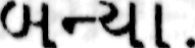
બન્યા.
